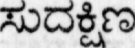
ಸುದಕ್ಷಿಣ
